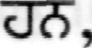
ਹਨ,
